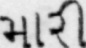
મારી
